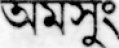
অমসুং
